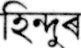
হিন্দুৰ
